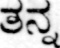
ತನ್ನ
